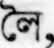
লৈ,
